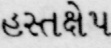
હસ્તક્ષેપ
